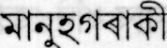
মানুহগৰাকী
